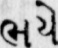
ભયે
